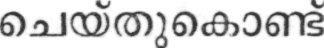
ചെയ്തുകൊണ്ട്
